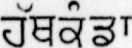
ਹੱਥਕੰਡਾ
